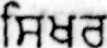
ਸਿਖਰ
